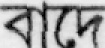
বাদে
